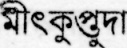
মীৎকুপ্তুদা
